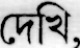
দেখি,
